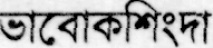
ভাবোকশিংদা
